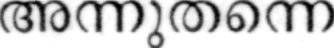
അന്നുതന്നെ
